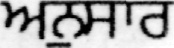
ਅਨੁਸਾਰ
